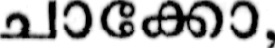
ചാക്കോ,
